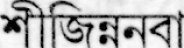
শীজিন্ননবা
